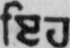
ਇਹ
